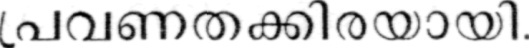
പ്രവണതക്കിരയായി.
